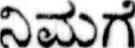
ನಿಮಗೆ
